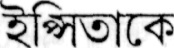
ইপ্সিতাকে
